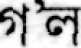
গ'ল
